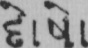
દોષો
